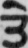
ਤੇ
